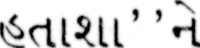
હતાશા"ને
